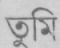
তুমি
